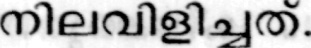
നിലവിളിച്ചത്.
